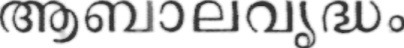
ആബാലവൃദ്ധം
